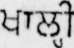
ਖਾਲ੍ਹੀ
